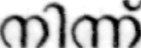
നിന്ന്
